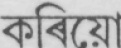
কৰিয়ো
